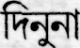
দিনুনা
